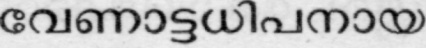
വേണാട്ടധിപനായ
